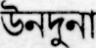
উনদুনা
